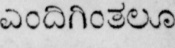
ಎಂದಿಗಿಂತಲೂ
